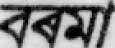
বৰমা
